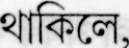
থাকিলে,
